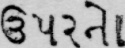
ઉપરનો
